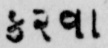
કરવા
